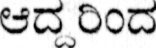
ಆದ್ದರಿಂದ
